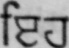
ਇਹ
